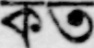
কত
